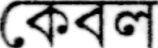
কেবল
